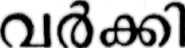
വര്‍ക്കി
